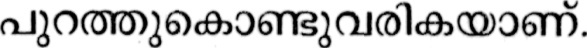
പുറത്തുകൊണ്ടുവരികയാണ്.
